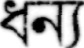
ধন্য
